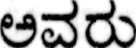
ಅವರು
